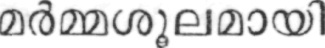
മര്‍മ്മശൂലമായി
